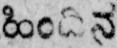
ಹಿಂದಿನ
